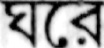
ঘরে
